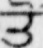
ਤੋਂ
